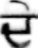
ਦੇ
